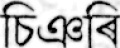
চিঞৰি
